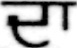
ਦਾ
